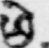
છે.
